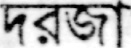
দরজা
